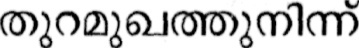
തുറമുഖത്തുനിന്ന്
